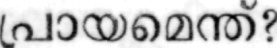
പ്രായമെന്ത്?
